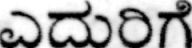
ಎದುರಿಗೆ
